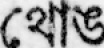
থোঙ
